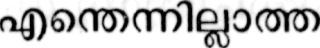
എന്തെന്നില്ലാത്ത
